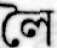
লৈ
